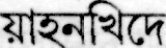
য়াহনখিদে
